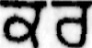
ਕਰ
